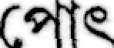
পোৎ
